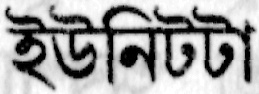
ইউনিটটা
